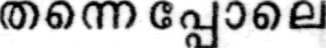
തന്നെപ്പോലെ
